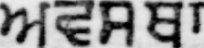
ਅਵਸਥਾ
